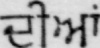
ਦੀਆਂ
